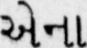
એના
